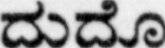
ದುದೊ
